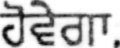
ਹੋਵੇਗਾ,
